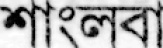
শাংলবা
